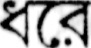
ধরে
